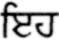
ਇਹ
